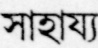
সাহায্য
